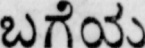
ಬಗೆಯ
